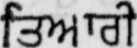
ਤਿਆਰੀ
